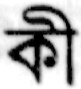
কী
